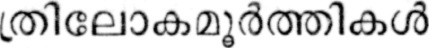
ത്രിലോകമൂര്‍ത്തികള്‍
